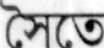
সৈতে
